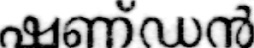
ഷണ്ഡന്‍
